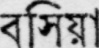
বসিয়া
